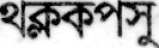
থক্লকপসু
